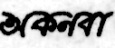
অকনবা
